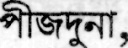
পীজদুনা,
